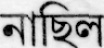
নাছিল
